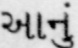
આનું
